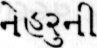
નેહરુની
